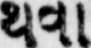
થવા
